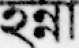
হন্না
